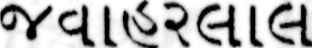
જવાહરલાલ
